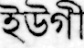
ইউগী
